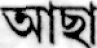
আছা
